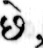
છે,
